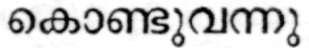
കൊണ്ടുവന്നു
